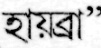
হায়ব্রা”
